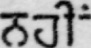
ਨਹੀਂ
